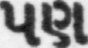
પણ
